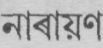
নাৰায়ণ
